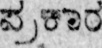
ಪ್ರಕಾರ
